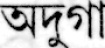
অদুগা
